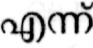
എന്ന്
